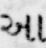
આ
